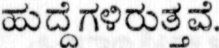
ಹುದ್ದೆಗಳಿರುತ್ತವೆ.
